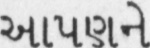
આપણને
